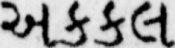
અકકલ
